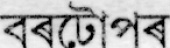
বৰটোপৰ
